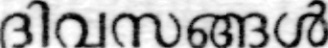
ദിവസങ്ങള്‍
